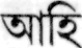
আহি
